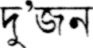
দু’জন
